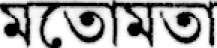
মতোমতা
